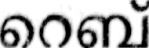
റെബ്
